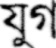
যুগ
